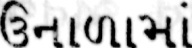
ઉનાળામાં
